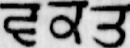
ਵਕਤ
